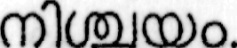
നിശ്ചയം.
